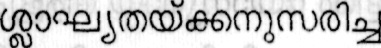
ശ്ലാഘ്യതയ്ക്കനുസരിച്ച
